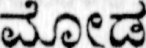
ಮೋಡ
